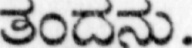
ತಂದನು.
